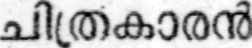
ചിത്രകാരന്‍
